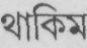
থাকিম
